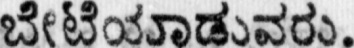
ಬೇಟೆಯಾಡುವರು.
